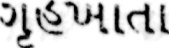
ગૃહખાતા
